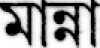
মান্না
